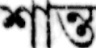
শান্ত
